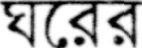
ঘরের
